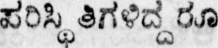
ಪರಿಸ್ಥಿತಿಗಳಿದ್ದರೂ
